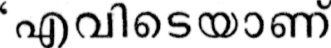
‘എവിടെയാണ്
